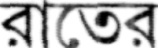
রাতের
